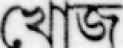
খোজ
